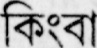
কিংবা
